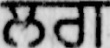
ਲਗ
